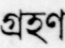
গ্রহণ
